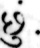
છું.
